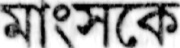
মাংসকে
